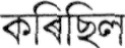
কৰিছিল
